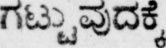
ಗಟ್ಟುವುದಕ್ಕೆ
